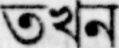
তখন
